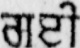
ਗਈ
